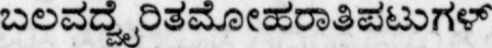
ಬಲವದ್ವೈರಿತಮೋಹರಾತಿಪಟುಗಳ್
